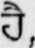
ਹੈ,
